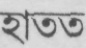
হাতত
